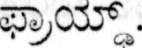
ಫ್ರಾಯ್ಡ್,
